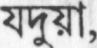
যদুয়া,
